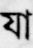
যা
